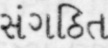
સંગઠિત
